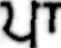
ਪਾ
